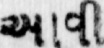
આવી
